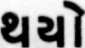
થયો
